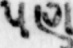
પણ
